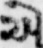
એ
